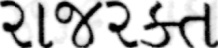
રાજરક્ત
